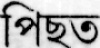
পিছত
